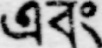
এবং
